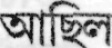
আছিল
